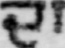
ਦਾ
